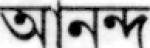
আনন্দ
